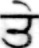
ਤੇ
